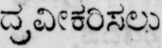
ದ್ರವೀಕರಿಸಲು
